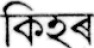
কিহৰ
